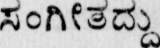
ಸಂಗೀತದ್ದು
